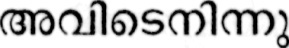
അവിടെനിന്നു
